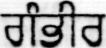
ਗੰਭੀਰ
